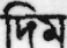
দিম
